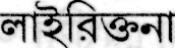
লাইরিক্তনা
